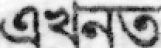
এখনত
